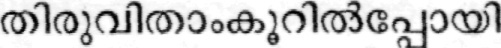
തിരുവിതാംകൂറില്‍പ്പോയി
